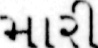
મારી
